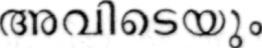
അവിടെയും
